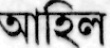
আহিল
